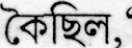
কৈছিল,
